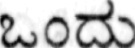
ಒಂದು
